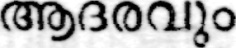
ആദരവും
